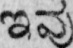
ಇವು
